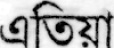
এতিয়া
